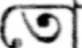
তো
